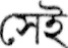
সেই
